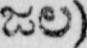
ಜಲ)
